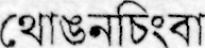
থোঙনচিংবা
